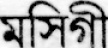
মসিগী
